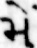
મેં
